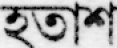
হতাশ
